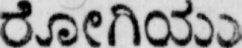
ರೋಗಿಯು
